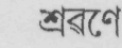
শ্ৰৱণে
